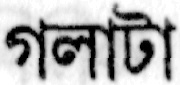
গলাটা
